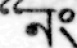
“নং
